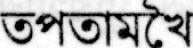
তপতামখৈ
